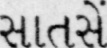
સાતસેં
